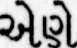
એણે
